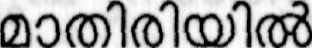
മാതിരിയില്‍
